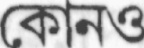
কোনও
